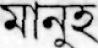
মানুহ
